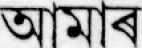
আমাৰ
